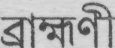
ব্ৰাহ্মণী
